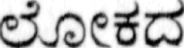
ಲೋಕದ
